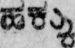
ಹಕ್ಕು
